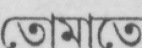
তোমাতে
